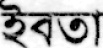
ইবতা
